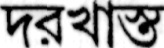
দরখাস্ত
